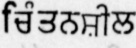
ਚਿੰਤਨਸ਼ੀਲ
